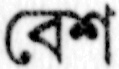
বেশ
